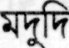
মদুদি
